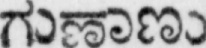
ಗುಣಾಣು
